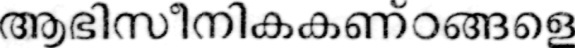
ആഭിസീനികകണ്ഠങ്ങളെ
